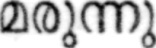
മരുന്നു
